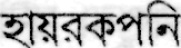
হায়রকপনি
